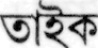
তাইক
